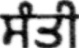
ਸੰਤੀ
